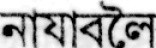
নাযাবলৈ
